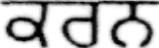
ਕਰਨ
